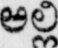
ಅಲ್ಲಿ
